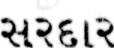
સરદાર
